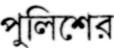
পুলিশের
